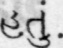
હતું.
